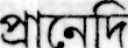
প্রানেদি
